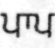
ਪਾਪ
